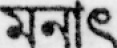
মনাৎ
